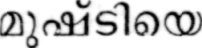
മുഷ്ടിയെ
